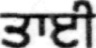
ਤਾਈ
